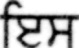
ਇਸ
